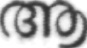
ആ
